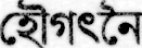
হৌগৎনৈ
